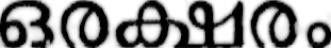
ഒരക്ഷരം
